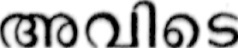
അവിടെ
